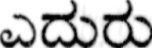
ಎದುರು
